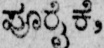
ಪೂರೈಕೆ,
